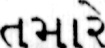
તમારે
